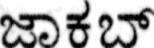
ಜಾಕಬ್
